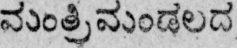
ಮಂತ್ರಿಮಂಡಲದ
